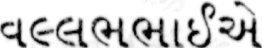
વલ્લભભાઈએ
